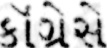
કૉંગ્રેસે
